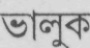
ভালুক
